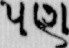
સાધન
